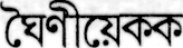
ঘৈণীয়েকক
